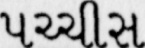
પચ્ચીસ
